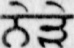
ਨੇੜੇ
